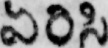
ಏರಿಸಿ
